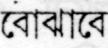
বোঝাবে
